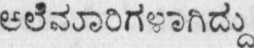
ಅಲೆಮಾರಿಗಳಾಗಿದ್ದು
